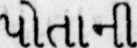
પોતાની
